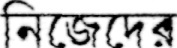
নিজেদের
